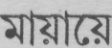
মায়ায়ে
